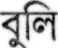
বুলি
